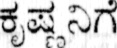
ಕೃಷ್ಣನಿಗೆ
